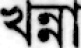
খন্না
